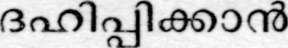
ദഹിപ്പിക്കാന്‍
